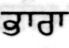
ਭਾਰਾ
